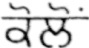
ਕੋਲੋਂ
